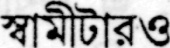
স্বামীটারও
